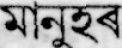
মানুহৰ
